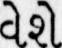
વેશે
